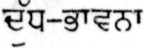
ਦੁੱਧ-ਭਾਵਨਾ
